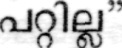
പറ്റില്ല”
